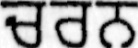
ਚਰਨ
